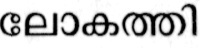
ലോകത്തി
